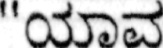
“ಯಾವ
